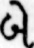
બે
